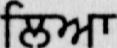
ਲਿਆ
